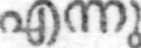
എന്നു
